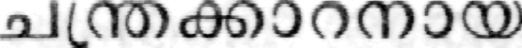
ചന്ത്രക്കാറനായ
